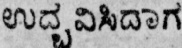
ಉದ್ಭವಿಸಿದಾಗ
